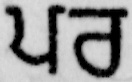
ਪਰ
